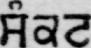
ਸੰਕਟ
